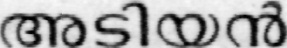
അടിയന്‍
